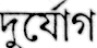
দুর্যোগ
